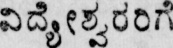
ವಿದ್ಯೇಶ್ವರರಿಗೆ
